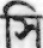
সি
